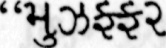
"મુઝફ્ફર
